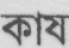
কাষ
